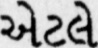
એટલે
